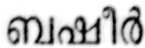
ബഷീര്‍
